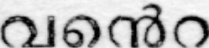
വന്റെ
